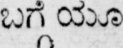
ಬಗ್ಗೆಯೂ
